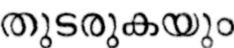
തുടരുകയും
